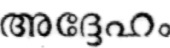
അദ്ദേഹം
